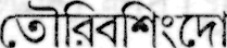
তৌরিবশিংদো
